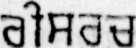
ਰੀਸਰਚ
